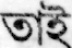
তাই
